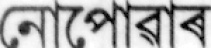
নোপোৱাৰ
